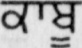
ਕਾਬੂ
